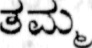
ತಮ್ಮ
